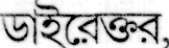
ডাইরেক্তর,
